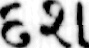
દશ
